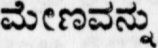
ಮೇಣವನ್ನು
